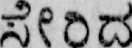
ಸೇರಿದ
